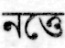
নত্তে
